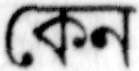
কেন
